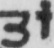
ਤਾਂ
